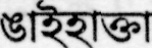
ঙাইহাক্তা
